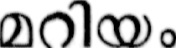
മറിയം
